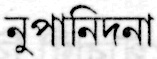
নুপানিদনা
